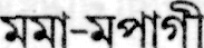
মমা-মপাগী
